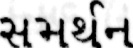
સમર્થન
